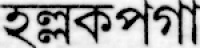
হল্লকপগা
